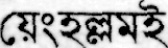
য়েংহল্লমই
